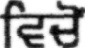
ਵਿਚੋਂ
